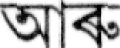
আৰু
